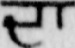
ਦਾ
